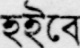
হইবে
